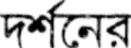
দর্শনের
